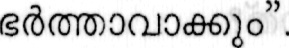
ഭര്‍ത്താവാക്കും".
